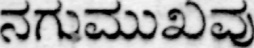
ನಗುಮುಖವು
